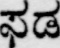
ಫಡ
